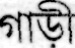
গাড়ী
